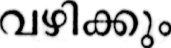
വഴിക്കും
